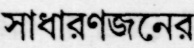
সাধারণজনের
